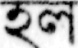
হল
